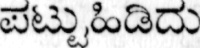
ಪಟ್ಟುಹಿಡಿದು
